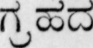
ಗ್ರಹದ
